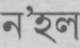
ন'হল
